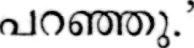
പറഞ്ഞു.'
